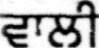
ਵਾਲੀ
